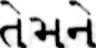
તેમને
